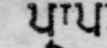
ਪ੍ਰਾਪਾ
